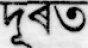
দূৰত
